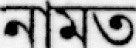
নামত
